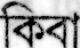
কিবা
